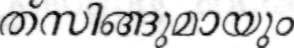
ത്സിങ്ങുമായും
